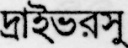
দ্রাইভরসু
